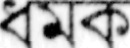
ধমক
